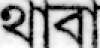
থাবা
